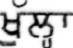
ਖੁੱਲ੍ਹਾ
